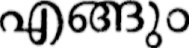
എങ്ങും
